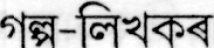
গল্প-লিখকৰ
